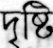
দৃষ্টি
